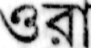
ওরা
